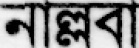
নাল্লবা
